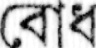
বোধ
